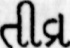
તીવ્ર
